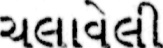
ચલાવેલી
